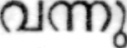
വന്നു
